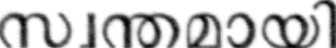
സ്വന്തമായി
